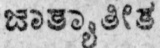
ಜಾತ್ಯಾತೀತ
